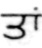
ਤਾਂ
